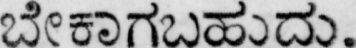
ಬೇಕಾಗಬಹುದು.
